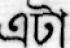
এটা
